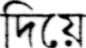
দিয়ে
